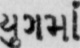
યુગમાં
